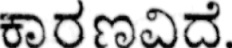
ಕಾರಣವಿದೆ.
